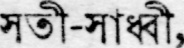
সতী-সাধ্বী,
